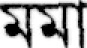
মমা
